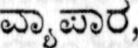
ವ್ಯಾಪಾರ,
